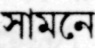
সামনে
